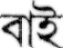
বাই
